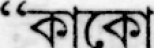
"কাকো
